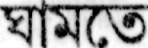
ঘামতে
